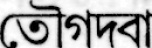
তৌগদবা
